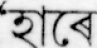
'হাৰে
